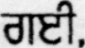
ਗਈ,
